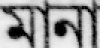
মানা
